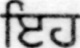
ਇਹ
